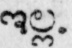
ಇಲ್ಲ.
